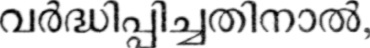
വര്‍ദ്ധിപ്പിച്ചതിനാല്‍,
